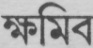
ক্ষমিব
